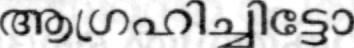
ആഗ്രഹിച്ചിട്ടോ
